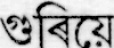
গুৰিয়ে
